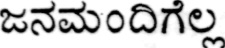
ಜನಮಂದಿಗೆಲ್ಲ
